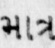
માત્ર
